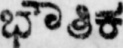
ಭೌತಿಕ
